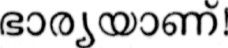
ഭാര്യയാണ്!
